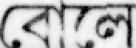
বোলে
